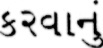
કરવાનું
